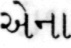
એના
